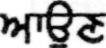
ਆਉਣ
